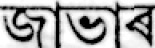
জাভাৰ
